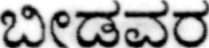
ಬೀಡವರ
